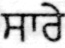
ਸਾਰੇ
